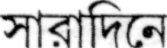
সারাদিনে
